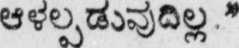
ಆಳಲ್ಪಡುವುದಿಲ್ಲ.”
